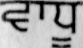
ਵਾਧੂ
